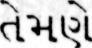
તેમણે
